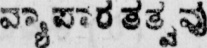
ವ್ಯಾಪಾರತತ್ವವು
